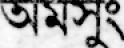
অমসুং
